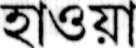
হাওয়া
